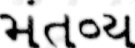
મંતવ્ય
